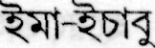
ইমা-ইচাবু
